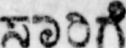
ಸಾರಿಗೆ
